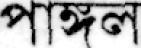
পাঙ্গল
